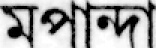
মপান্দা
